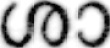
ശാ
